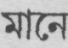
মানে
